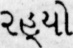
રહ્યો
